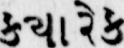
ક્યારેક
